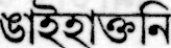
ঙাইহাক্তনি
